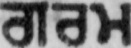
ਗਰਮ
